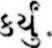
કર્યું.
